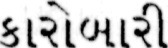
કારોબારી
